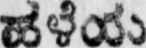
ಹಳೆಯ
